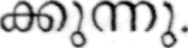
ക്കുന്നു.
